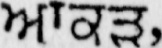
ਆਕੜ,
